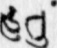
હતું
